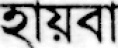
হায়বা
